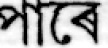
পাৰে
